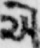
એ
